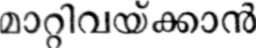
മാറ്റിവയ്ക്കാന്‍
